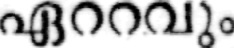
ഏററവും
